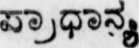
ಪ್ರಾಧಾನ್ಯ
